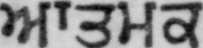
ਆਤਮਕ
